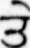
ਤੇ
